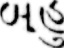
બહુ
